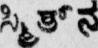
ಸ್ಮಿತ್‌ನ
